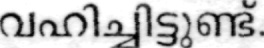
വഹിച്ചിട്ടുണ്ട്.
